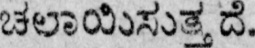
ಚಲಾಯಿಸುತ್ತದೆ.
